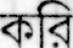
করি
